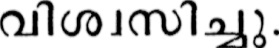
വിശ്വസിച്ചു.
